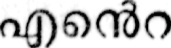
എന്റെ
